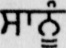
ਸਾਨੂੰ
